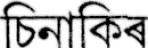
চিনাকিৰ
